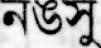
নঙসু
